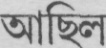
আছিল
